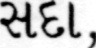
સદા,
